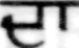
ਦਾ
